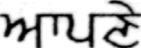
ਆਪਣੇ
